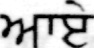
ਆਏ
